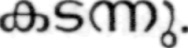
കടന്നു.
